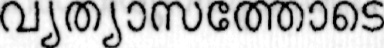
വ്യത്യാസത്തോടെ
